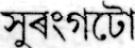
সুৰংগটো
